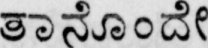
ತಾನೊಂದೇ
